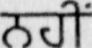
ਨਹੀਂ
